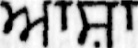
ਆਸ਼ਾ
